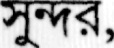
সুন্দর,
